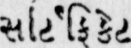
સર્ટિફિકેટ
